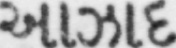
આઝાદ
